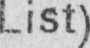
List)
